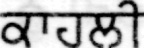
ਕਾਹਲੀ
